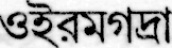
ওইরমগদ্রা
